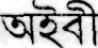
অইবী
